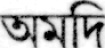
অমদি
